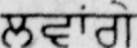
ਲਵਾਂਗੇ
